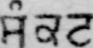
ਸੰਕਟ
